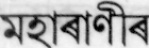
মহাৰাণীৰ
